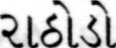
રાઠોડો
